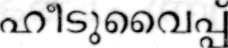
ഹീടുവൈപ്പ്
